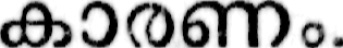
കാരണം.
